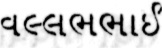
વલ્લભભાઈ
